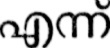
എന്ന്
